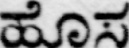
ಹೊಸ
